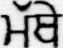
ਮੱਥੇ
